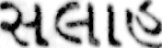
સલાહ
